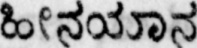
ಹೀನಯಾನ
